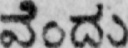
ವೆಂದು
